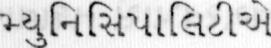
મ્યુનિસિપાલિટીએ
